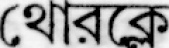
থোরক্লে
